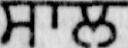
ਸਾਲ
